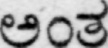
ಅಂತ
